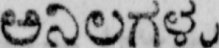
ಅನಿಲಗಳು
